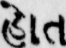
હોત
